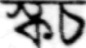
স্কচ
